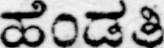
ಹೆಂಡತಿ
